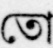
তো
